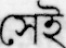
সেই
